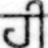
ਹੀ
